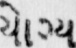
યોગ્ય
